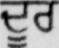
ਦੂਰ
